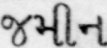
જમીન
